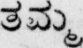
ತಮ್ಮ
